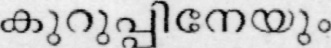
കുറുപ്പിനേയും
